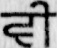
ਵੀ
